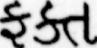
ફક્ત
